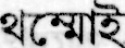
থম্মোই
